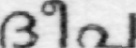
ദീപ
